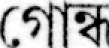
গোন্ধ
